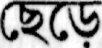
ছেড়ে
